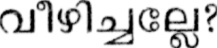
വീഴിച്ചല്ലേ?
